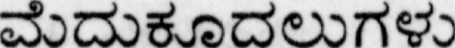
ಮೆದುಕೂದಲುಗಳು
